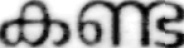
കണ്ട
